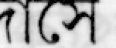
দাসে
